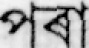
পৰা
